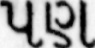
પણ
